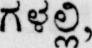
ಗಳಲ್ಲಿ,
